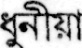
ধুনীয়া
